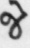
જે
